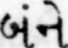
બંને
